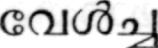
വേള്‍ച്ച
